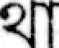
থা
